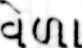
વેળા
